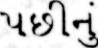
પછીનું
